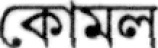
কোমল
